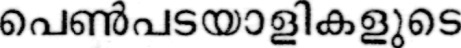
പെണ്‍പടയാളികളുടെ
